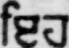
ਇਹ
